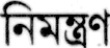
নিমন্ত্রণ
